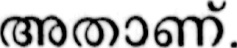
അതാണ്.
